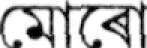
মোৰো
